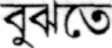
বুঝতে
